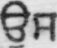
ਉਸ
